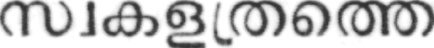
സ്വകളത്രത്തെ
